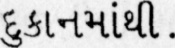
દુકાનમાંથી.
